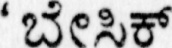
‘ಬೇಸಿಕ್
